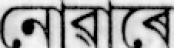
নোৱাৰে
